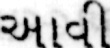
આવી
